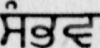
ਸੰਭਵ
